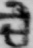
ਦੇ
